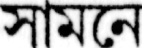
সামনে
